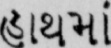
હાથમાં
